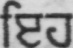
ਇਹ
